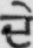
ਦੇ
